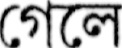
গেলে
